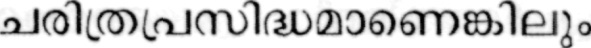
ചരിത്രപ്രസിദ്ധമാണെങ്കിലും
